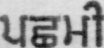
ਪਛਮੀ
